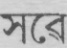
সৱে
